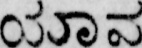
ಯಾವ
